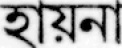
হায়না
